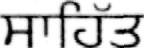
ਸਾਹਿੱਤ
